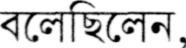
বলেছিলেন,
